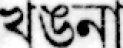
খঙনা
